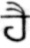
ਹੈ
